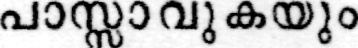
പാസ്സാവുകയും
